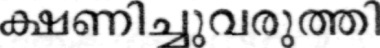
ക്ഷണിച്ചുവരുത്തി
